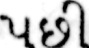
પછી
